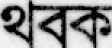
থবক
